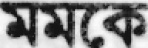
মমকে
